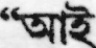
"আই
